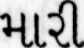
મારી
